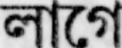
লাগে
